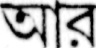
আর
